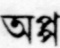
অপ্প
